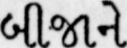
બીજાને
